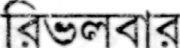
রিভলবার
